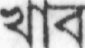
খাব
